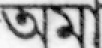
অমা
